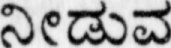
ನೀಡುವ
